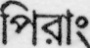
পিরাং
